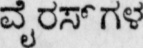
ವೈರಸ್‌ಗಳ
